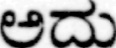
ಅದು
